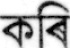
কৰি
